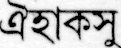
ঐহাকসু
